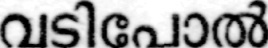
വടിപോല്‍
